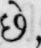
છે,
